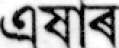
এষাৰ
